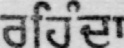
ਰਹਿੰਦਾ
